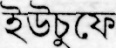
ইউচুফে
